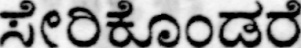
ಸೇರಿಕೊಂಡರೆ
